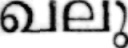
ഖലു
